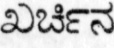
ಖರ್ಚಿನ
